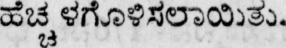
ಹೆಚ್ಚಳಗೊಳಿಸಲಾಯಿತು.
